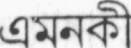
এমনকী
